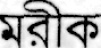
মরীক
